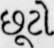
છૂટો
